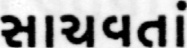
સાચવતાં
